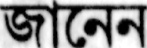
জানেন
